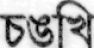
চঙখি
